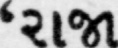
'રાજા
